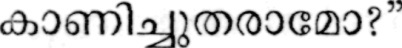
കാണിച്ചുതരാമോ?"
